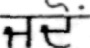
ਜਦੋਂ
